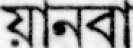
য়ানবা
